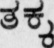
ತಕ್ಕ
